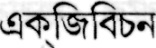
এক্‌জিবিচন
